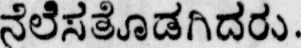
ನೆಲೆಸತೊಡಗಿದರು.
